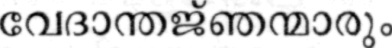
വേദാന്തജ്ഞന്മാരും
